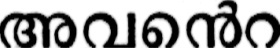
അവന്റെ
